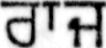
ਰਾਜ
